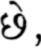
છે,
